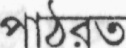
পাঠরত
